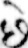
છે
